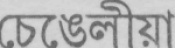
চেঙেলীয়া
